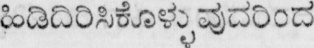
ಹಿಡಿದಿರಿಸಿಕೊಳ್ಳುವುದರಿಂದ
